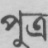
পুত্ৰ
